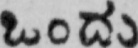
ಒಂದು
